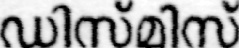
ഡിസ്മിസ്
